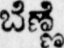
ಬೆಣ್ಣೆ
